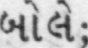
બોલે;
